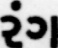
રંગ
